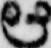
ಆ
